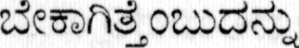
ಬೇಕಾಗಿತ್ತೆಂಬುದನ್ನು
